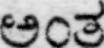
ಅಂತ
